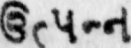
ઉત્પન્ન
